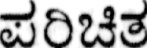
ಪರಿಚಿತ
